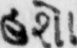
હશો
